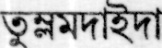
তুম্লমদাইদা
